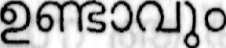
ഉണ്ടാവും
